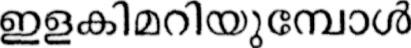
ഇളകിമറിയുമ്പോള്‍
